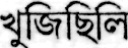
খুজিছিলি
